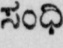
ಸಂಧಿ
